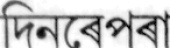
দিনৰেপৰা
